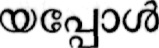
യപ്പോള്‍
